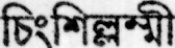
চিংশিল্লম্মী
